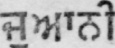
ਜੁਆਨੀ
